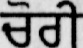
ਚੋਰੀ
